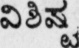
ವಿಶಿಷ್ಟ
